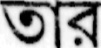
তার
